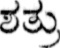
ಶತ್ರು
